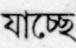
যাচ্ছে
